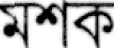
মশক
